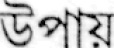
উপায়
